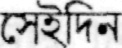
সেইদিন
